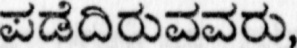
ಪಡೆದಿರುವವರು,
